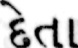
દેતા
